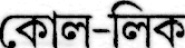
কোল-লিক
